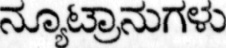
ನ್ಯೂಟ್ರಾನುಗಳು
